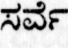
ಸರ್ವೆ
